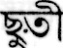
ছুতী
